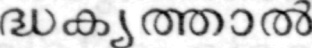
ദ്ധക്യത്താല്‍
